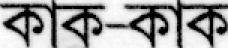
কাক-কাক
